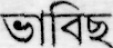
ভাবিছ
